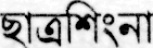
ছাত্রশিংনা
